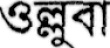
ওল্লুবা
